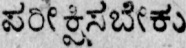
ಪರೀಕ್ಷಿಸಬೇಕು
